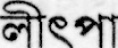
লীৎপা
